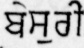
ਬੇਸੁਰੀ
